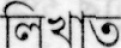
লিখাত
